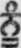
ਨੂੰ
